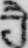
ਹੈ
